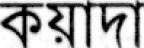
কয়াদা
